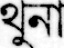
থুনা
